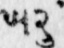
ખરું
